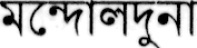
মন্দোলদুনা
